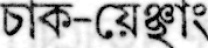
চাক-য়েঞ্ছাং
